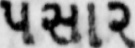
પસાર
